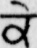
ਕੇ
